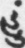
હું
